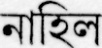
নাহিল
